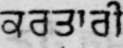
ਕਰਤਾਰੀ
